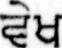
ਵੇਖ
